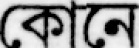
কোনে
